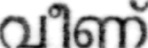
വീണ്
